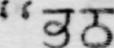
''ਭਠ
